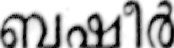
ബഷീര്‍
